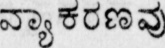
ವ್ಯಾಕರಣವು
